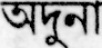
অদুনা
